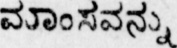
ಮಾಂಸವನ್ನು
